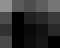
করিগীনো
